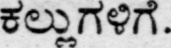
ಕಲ್ಲುಗಳಿಗೆ.
